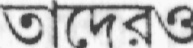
তাদেরও
